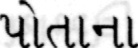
પોતાના
